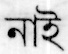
নাই
